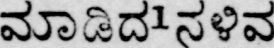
ಮಾಡಿದ1ನಳಿವ
